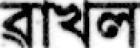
ৱাখল
